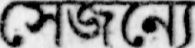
সেজন্যে
